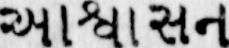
આશ્વાસન
